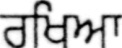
ਰਖਿਆ
